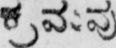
ಕ್ರಮವು
